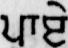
ਪਾਏ
